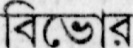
বিভোর
